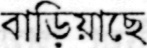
বাড়িয়াছে
